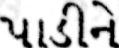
પાડીને
